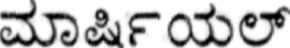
ಮಾರ್ಷಿಯಲ್
